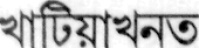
খাটিয়াখনত
